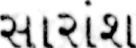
સારાંશ
